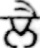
ਲੈ
